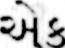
એક
